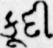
કૂદી
